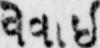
વેવાઈ
